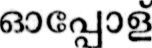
ഓപ്പോള്
